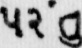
,પરંતુ
